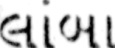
લાંબા
